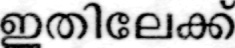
ഇതിലേക്ക്
